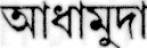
আধামুদা
